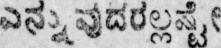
ಎನ್ನುವುದರಲ್ಲಷ್ಟೇ
